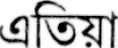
এতিয়া
